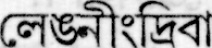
লেঙনীংদ্রিবা
